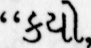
"કયો,
